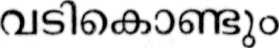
വടികൊണ്ടും
